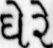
ઘેરે
